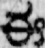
ಈ
